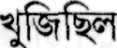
খুজিছিল
